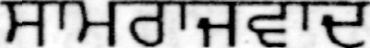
ਸਾਮਰਾਜਵਾਦ
